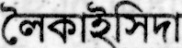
লৈকাইসিদা
